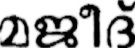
മജീദ്
